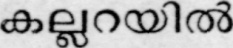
കല്ലറയില്‍
